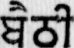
ਬੈਠੀ
